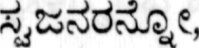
ಸ್ವಜನರನ್ನೋ,
